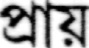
প্রায়
